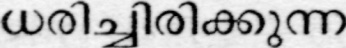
ധരിച്ചിരിക്കുന്ന
